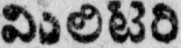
ಮಿಲಿಟರಿ
